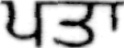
ਪਤਾ
